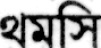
থমসি
